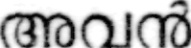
അവന്‍
